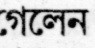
গেলেন
